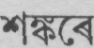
শঙ্কৰে
